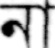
না
